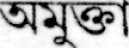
অমুক্তা
